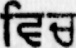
ਵਿਚ
